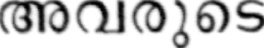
അവരുടെ
